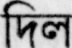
দিল
